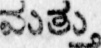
ಮತ್ತು
